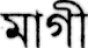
মাগী
